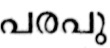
പരപു
